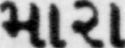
મારા
